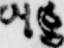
બહુ
